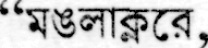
“মঙলাক্নরে,
